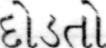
દોડતો
